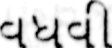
વધવી
